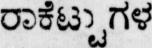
ರಾಕೆಟ್ಟುಗಳ
